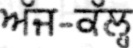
ਅੱਜ-ਕੱਲ੍ਹ
